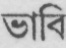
ভাবি
